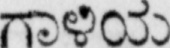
ಗಾಳಿಯ
